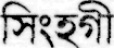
সিংহগী
